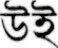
উই
